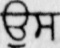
ਉਸ
